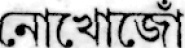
নোখোজোঁ
